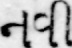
નવી
